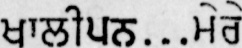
ਖਾਲੀਪਨ............ਮੇਰੇ
